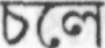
চলে
